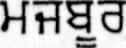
ਮਜਬੂਰ
